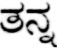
ತನ್ನ
